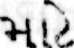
માટે
